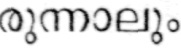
രുന്നാലും
